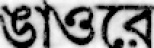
ঙাওরে
